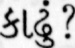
કાઢું?
